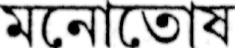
মনোতোষ
